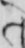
તે
